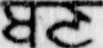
ਬਣ
